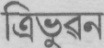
ত্ৰিভুৱন
